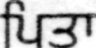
ਪਿਤਾ
